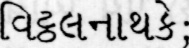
વિઠ્ઠલનાથકે;
